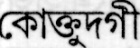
কোক্তুদগী
